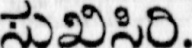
ಸುಖಿಸಿರಿ.
